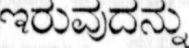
ಇರುವುದನ್ನು
